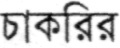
চাকরির
